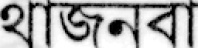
থাজনবা
